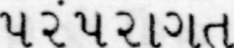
પરંપરાગત
